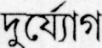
দুর্য্যোগ
